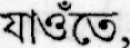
যাওঁতে,
